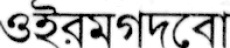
ওইরমগদবো
